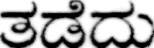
ತಡೆದು
